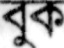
বুক
